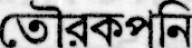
তৌরকপনি
